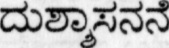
ದುಶ್ಯಾಸನನೆ
